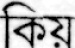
কিয়
